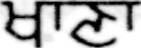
ਖਾਣਾ
